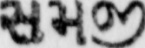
સમજી
